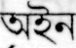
অইন
